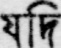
যদি
